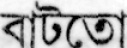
বাটতো
